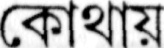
কোথায়
